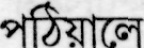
পঠিয়ালে
